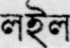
লইল
